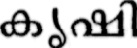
കൃഷി
